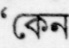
‘কেন
